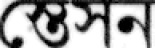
স্তেসন
